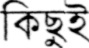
কিছুই
